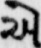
એ
